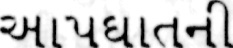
આપઘાતની
